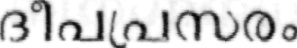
ദീപപ്രസരം
